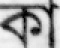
কা
